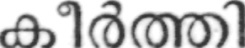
കീര്‍ത്തി
